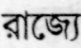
রাজ্যে
